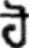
ਹੋ
